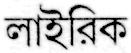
লাইরিক
